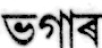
ভগাৰ
